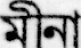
মীনা
